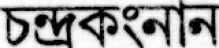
চন্দ্রকংনান
